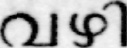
വഴി
